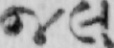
જલ
